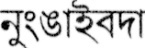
নুংঙাইবদা
